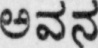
ಅವನ
